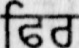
ਫਿਰ
